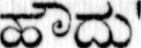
ಹೌದು’
